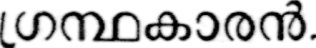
ഗ്രന്ഥകാരന്‍.
